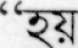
"হয়
